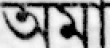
অমা
